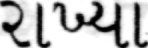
રાખ્યા
